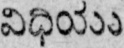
ವಿಧಿಯು
